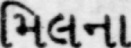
મિલના
